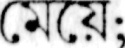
মেয়ে;
